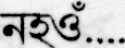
নহওঁ....
